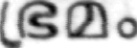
ഭ്രമം
